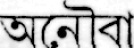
অনৌবা
